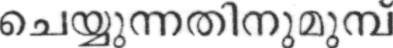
ചെയ്യുന്നതിനുമുമ്പ്
